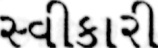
સ્વીકારી
